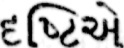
દૃષ્ટિએ
